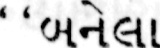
"બનેલા
